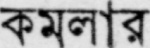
কমলার
